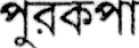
পুরকপা
